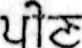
ਪੀਣ
